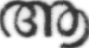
ആ
